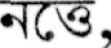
নত্তে,
